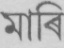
মাৰি
